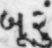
બૂરું
